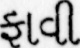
ફાવી
